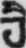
ਹੈ
